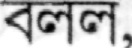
বলল,
